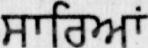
ਸਾਰਿਆਂ
